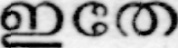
ഇതേ
